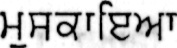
ਮੁਸਕਾਇਆ
